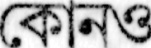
কোনও
